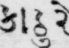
કાઠુરે
